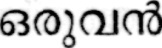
ഒരുവന്‍
